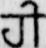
ਹੀ
